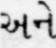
અને
